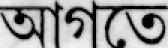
আগতে
